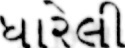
ધારેલી
